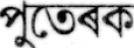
পুতেৰক
